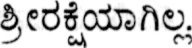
ಶ್ರೀರಕ್ಷೆಯಾಗಿಲ್ಲ.
